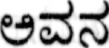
ಅವನ
